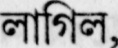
লাগিল,
